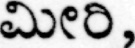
ಮೀರಿ,
